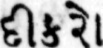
દીકરો
